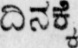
ದಿನಕ್ಕೆ
